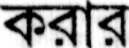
করার
